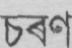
চৰণ
